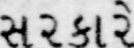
સરકારે
